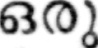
ഒരു
